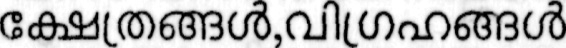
ക്ഷേത്രങ്ങള്‍,വിഗ്രഹങ്ങള്‍
